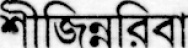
শীজিন্নরিবা
